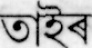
তাইৰ
